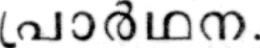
പ്രാര്‍ഥന.
